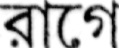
রাগে
